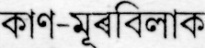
কাণ-মূৰবিলাক
